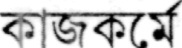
কাজকর্মে
